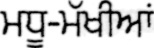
ਮਧੂ-ਮੱਖੀਆਂ
